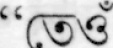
"তেওঁ
